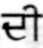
ਦੀ
